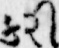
કરી
